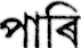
পাৰি
